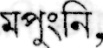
মপুংনি,
